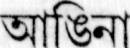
আঙিনা
